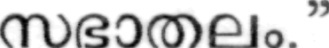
സഭാതലം."
